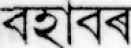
বহাবৰ
